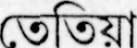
তেতিয়া
